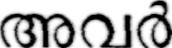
അവര്‍
